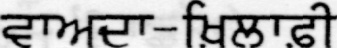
ਵਾਅਦਾ-ਖ਼ਿਲਾਫ਼ੀ
